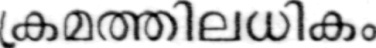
ക്രമത്തിലധികം
